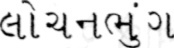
લોચનભુંગ
